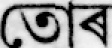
তোৰ
